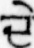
ਦੇ
